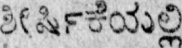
ಶೀರ್ಷಿಕೆಯಲ್ಲಿ
